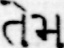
તેમ
